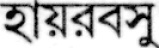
হায়রবসু
